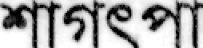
শাগৎপা
